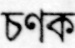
চণক
